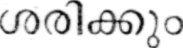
ശരിക്കും
